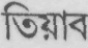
তিয়াব
